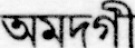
অমদগী
